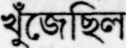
খুঁজেছিল
